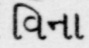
વિના
